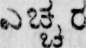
ಎಚ್ಚರ
